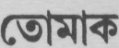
তোমাক
